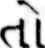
તો
